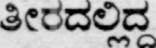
ತೀರದಲ್ಲಿದ್ದ
